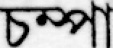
চম্পা
